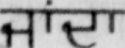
ਜਾਂਦਾ
